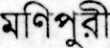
মণিপুরী
